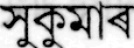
সুকুমাৰ
